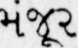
મંજૂર
